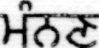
ਮੰਨਣ
